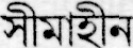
সীমাহীন
